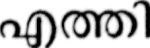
എത്തി
